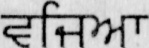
ਵਜਿਆ
